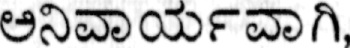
ಅನಿವಾರ್ಯವಾಗಿ,
